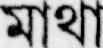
মাথা
